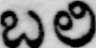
ಬಲಿ
